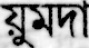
য়ুমদা
